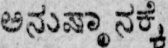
ಅನುಷ್ಠಾನಕ್ಕೆ
